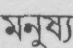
মনুষ্য
